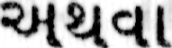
અથવા
